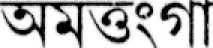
অমত্তংগা
